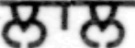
ਲਾਲ
